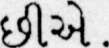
છીએ.
